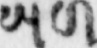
બળ
